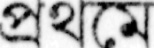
প্রথমে
